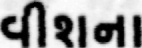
વીશના
